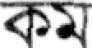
কম
